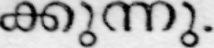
ക്കുന്നു.
